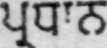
ਪ੍ਰਧਾਨ
